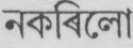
নকৰিলো
